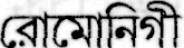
রোমোনিগী
